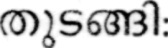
തുടങ്ങി:
